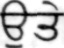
ਉਤੇ
